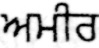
ਅਮੀਰ
